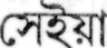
সেইয়া
